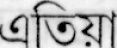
এতিয়া
